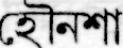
হৌনশা
